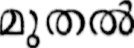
മുതല്‍
